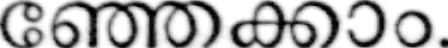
ഞ്ഞേക്കാം.
